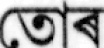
তোৰ
